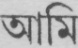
আমি
